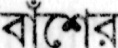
বাঁশের
